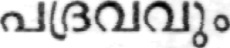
പദ്രവവും
